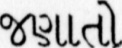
જણાતો
